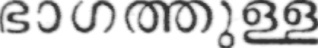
ഭാഗത്തുള്ള
